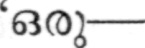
'ഒരു-
